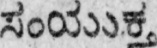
ಸಂಯುಕ್ತ
